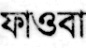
ফাওবা
